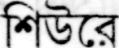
শিউরে
